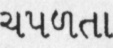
ચપળતા
